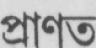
প্ৰাণত
